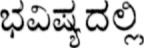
ಭವಿಷ್ಯದಲ್ಲಿ
